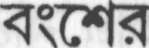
বংশের
